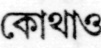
কোথাও
